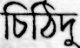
চিঠিদু
